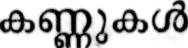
കണ്ണുകള്‍
